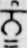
ਨੂੰ
